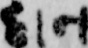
દાન
